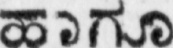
ಹಾಗೂ
